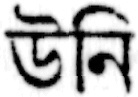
উনি
